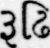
રૂઢિ
